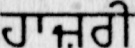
ਹਾਜ਼ਰੀ
